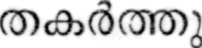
തകര്‍ത്തു
